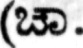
(ಚಾ.
